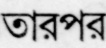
তারপর
